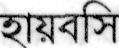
হায়বসি
